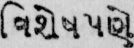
વિશેષપણે
